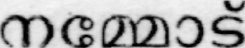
നമ്മോട്
